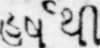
હર્ષથી
